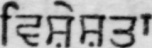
ਵਿਸ਼ੇਸ਼ਤਾ
